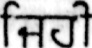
ਜਿਹੀ
